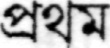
প্রথম
